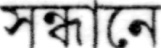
সন্ধানে
